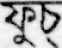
ফুচ্
